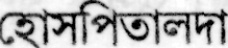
হোসপিতালদা
